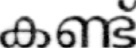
കണ്ട്
